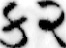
કર
